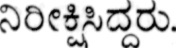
ನಿರೀಕ್ಷಿಸಿದ್ದರು.
